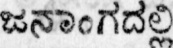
ಜನಾಂಗದಲ್ಲಿ
